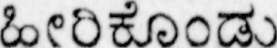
ಹೀರಿಕೊಂಡು
